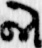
જો
